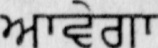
ਆਵੇਗਾ
